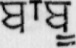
ਬਾਬੂ
